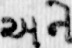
અને
